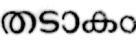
തടാകം
